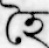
হৈ
